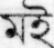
মই
